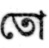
তো
